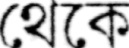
থেকে
